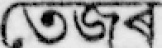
তেজৰ
